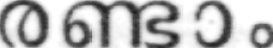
രണ്ടാം
